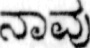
ನಾವು
